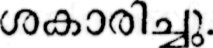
ശകാരിച്ചു.
